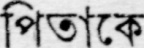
পিতাকে
